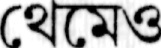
থেমেও
